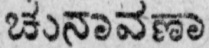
ಚುನಾವಣಾ
